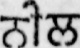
ਨੀਲ
